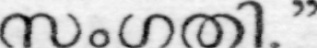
സംഗതി."
